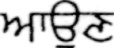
ਆਉਣ
